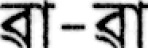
ৱা-ৱা
